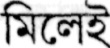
মিলেই
